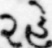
રહે
